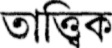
তাত্ত্বিক
